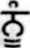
ਨੂੰ
